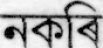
নকৰি
